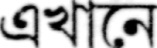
এখানে
